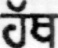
ਹੱਥ
